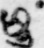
છું
